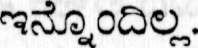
ಇನ್ನೊಂದಿಲ್ಲ.
